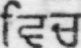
ਵਿਚ
